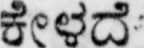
ಕೇಳದೆ
